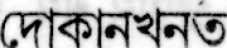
দোকানখনত
